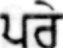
ਪਰੇ
